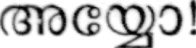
അയ്യോ!
